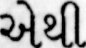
એથી
